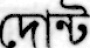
দোন্ট
